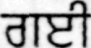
ਗਈ
